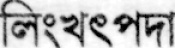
লিংখৎপদা
